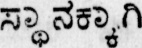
ಸ್ಥಾನಕ್ಕಾಗಿ
